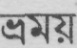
ভ্ৰময়
